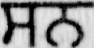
ਸਨ
